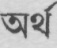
অৰ্থ
